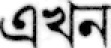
এখন
